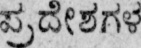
ಪ್ರದೇಶಗಳ
